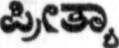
ಪ್ರೀತ್ಯಾ
